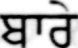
ਬਾਰੇ
